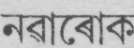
নৱাৰোক
